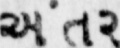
અંતર
